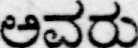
ಅವರು
